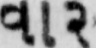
વાર
